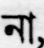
না,
